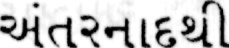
અંતરનાદથી
